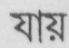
যায়
